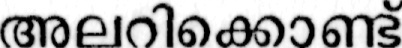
അലറിക്കൊണ്ട്
